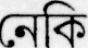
নেকি
